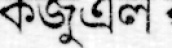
কেজুএল
